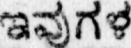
ಇವುಗಳ
